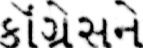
કૉંગ્રેસને
